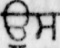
ਉਸ
